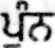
ਪੁੰਨ
